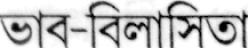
ভাব-বিলাসিতা
